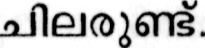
ചിലരുണ്ട്.
